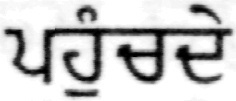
ਪਹੁੰਚਦੇ
